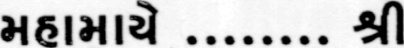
મહામાયે........શ્રી
